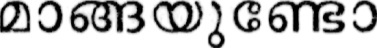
മാങ്ങയുണ്ടോ
